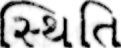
સ્થિતિ
